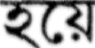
হয়ে
